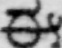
ಈ
